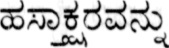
ಹಸ್ತಾಕ್ಷರವನ್ನು
